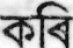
কৰি
